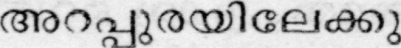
അറപ്പുരയിലേക്കു
